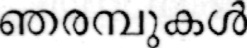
ഞരമ്പുകള്‍
